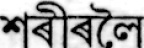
শৰীৰলৈ
